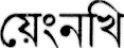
য়েংনখি
